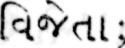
વિજેતા;
